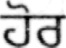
ਹੋਰ
